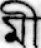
মী
